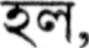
হল,
